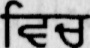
ਵਿਚ
